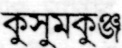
কুসুমকুঞ্জ
